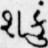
શકું
